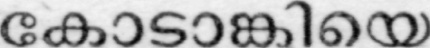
കോടാങ്കിയെ
